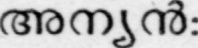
അന്യന്‍:
